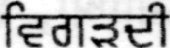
ਵਿਗੜਦੀ
